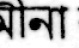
মীনা
